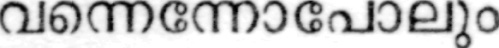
വന്നെന്നോപോലും
